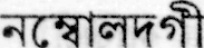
নম্বোলদগী
